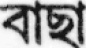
বাছা
